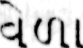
વેળા
